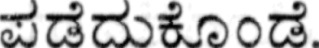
ಪಡೆದುಕೊಂಡೆ.
